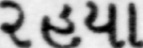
રહ્યા
